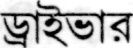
ড্রাইভার
